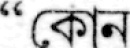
"কোন
